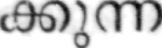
ക്കുന്ന
